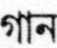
গান
